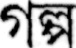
গল্প
